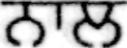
ਨਾਲ
